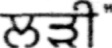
ਲੜੀ''
